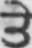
ਤੇ
